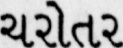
ચરોતર
